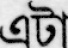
এটা
